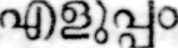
എളുപ്പം
